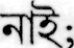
নাই;
